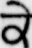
ਕੇ
